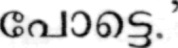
പോട്ടെ.'
